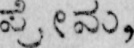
ಪ್ರೇಮ,
